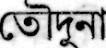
তৌদুনা
